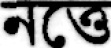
নত্তে
